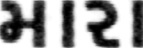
મારા
